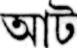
আট
